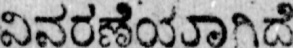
ವಿವರಣೆಯಾಗಿದೆ
